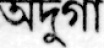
অদুগা
